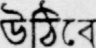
উঠিবে
